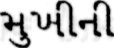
મુખીની
